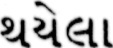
થયેલા
